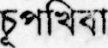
চূপখিবা
